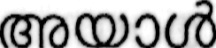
അയാള്‍
